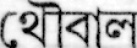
থৌবাল
